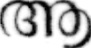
ആ
